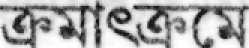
ক্রমাৎক্রমে
